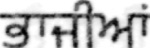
ਭਾਜੀਆਂ
